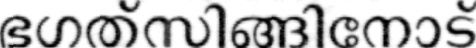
ഭഗത്സിങ്ങിനോട്
